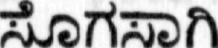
ಸೊಗಸಾಗಿ
